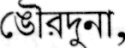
ঙৌরদুনা,
